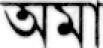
অমা
